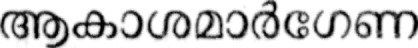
ആകാശമാര്‍ഗേണ
